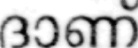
ദാണ്
